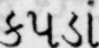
કપડાં
